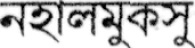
নহালমুকসু
